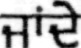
ਜਾਂਦੇ
